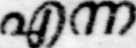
എന്ന
